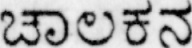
ಚಾಲಕನ
